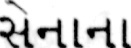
સેનાના
